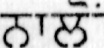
ਨਾਲੋਂ
